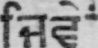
ਜਿਵੇਂ
